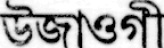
উজাওগী
